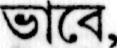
ভাবে,
